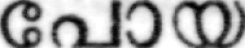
പോയ
